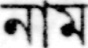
নাম
